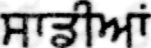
ਸਾਡੀਆਂ
